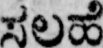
ಸಲಹೆ
